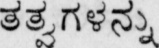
ತತ್ವಗಳನ್ನು
